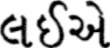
લઈએ
